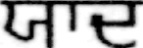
ਯਾਦ
